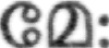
മേ:
